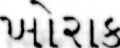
ખોરાક
